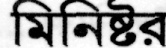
মিনিষ্টর
